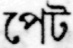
পেট
